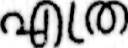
എത്ര
